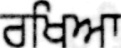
ਰਖਿਆ
